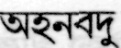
অহনবদু
